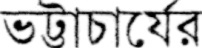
ভট্টাচার্যের
